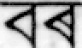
বৰ
